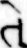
તે
